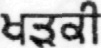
ਖੜਕੀ
